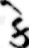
કે
